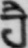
ਹੈ
